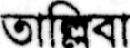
তাল্লিবা
